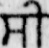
ਸੀ
